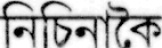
নিচিনাকৈ
